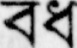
বধ
